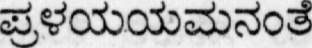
ಪ್ರಳಯಯಮನಂತೆ
